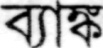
ব্যাঙ্ক
